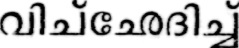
വിച്ഛേദിച്ച്
